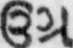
ઉગ્ર
